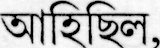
আহিছিল,
